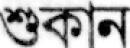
শুকান
